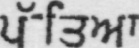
ਪੱਤਿਆ
